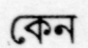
কেন
